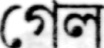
গেল
